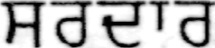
ਸਰਦਾਰ
